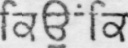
ਕਿਉਂਕਿ
